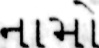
નામો
